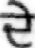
ਦੇ
